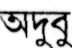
অদুবু
